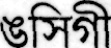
ঙসিগী
